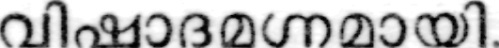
വിഷാദമഗ്നമായി.
